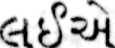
લઈએ
